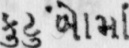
કુટુંબોમાં
